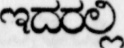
ಇದರಲ್ಲಿ
